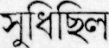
সুধিছিল
